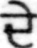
ਦੇ
